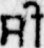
ਸੀ
